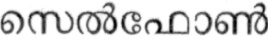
സെല്‍ഫോണ്‍
